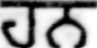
ਹਨ
